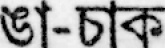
ঙা-চাক
